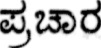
ಪ್ರಚಾರ
